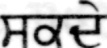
ਸਕਦੇ
